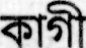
কাগী
